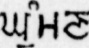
ਘੁੰਮਣ
